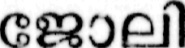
ജോലി
